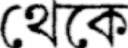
থেকে
